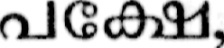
പക്ഷേ,
